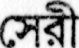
সেরী
